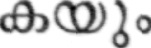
കയും
